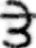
ਤੇ
